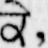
ਕੇ,
